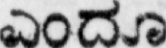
ಎಂದೂ
